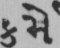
કર્મે
